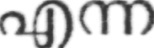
എന്ന
